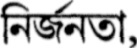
নির্জনতা,
